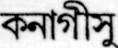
কনাগীসু
